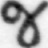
જ
